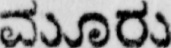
ಮೂರು
